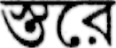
স্তরে
